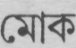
মোক
